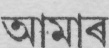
আমাৰ
